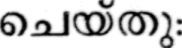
ചെയ്തു:
